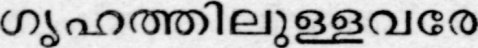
ഗൃഹത്തിലുള്ളവരേ
